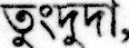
তুংদুদা,
